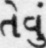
તેવું
